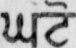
ਘਟੋ
